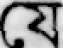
যে
